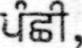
ਪੰਛੀ,
